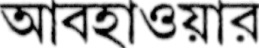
আবহাওয়ার
